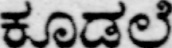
ಕೂಡಲೆ
